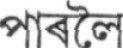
পাৰলৈ
